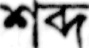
শব্দ
